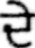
ਦੇ
